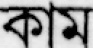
কাম
